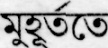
মুহূর্ততে
